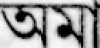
অমা
